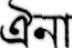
ঐনা
